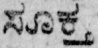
ಸೂಕ್ತ
